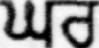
ਘਰ
